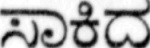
ಸಾಕಿದ
